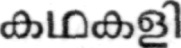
കഥകളി
